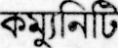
কম্যুনিটি
